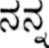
ನನ್ನ
